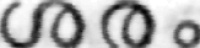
ശരം
